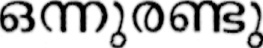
ഒന്നുരണ്ടു
